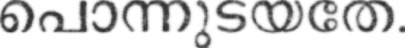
പൊന്നുടയതേ.
